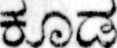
ಕೂಡ
